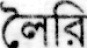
লৈরি
